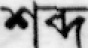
শব্দ
